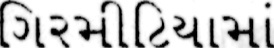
ગિરમીટિયામાં
